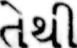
તેથી
